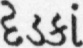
દેડકાં
